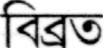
বিব্রত
